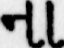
ના
